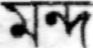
মন্দ
